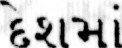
દેશમાં
